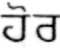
ਹੋਰ
